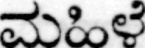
ಮಹಿಳೆ
